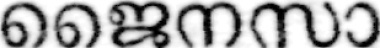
ജൈനസാ
